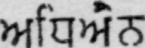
ਅਧਿਐਨ
